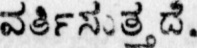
ವರ್ತಿಸುತ್ತದೆ.
